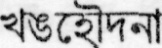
খঙহৌদনা
